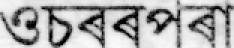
ওচৰৰপৰা
